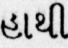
હાથી
